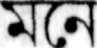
মনে
